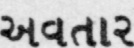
અવતાર
